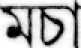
মচা
